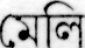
মেলি
